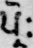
ਪ੍ਰੋ:
